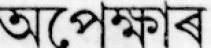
অপেক্ষাৰ
